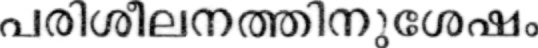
പരിശീലനത്തിനുശേഷം
